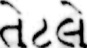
તેટલે
